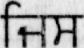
ਜਿਸ
